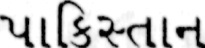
પાકિસ્તાન
